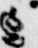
હું
